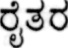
ರೈತರ
